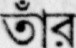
তাঁর
